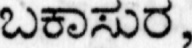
ಬಕಾಸುರ,
